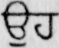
ਉਹ
